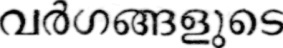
വര്‍ഗങ്ങളുടെ
